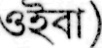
ওইবা)
